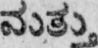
ಮತ್ತು
